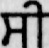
ਸੀ
